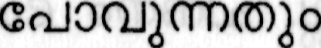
പോവുന്നതും
